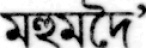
মহুমদৈ’
